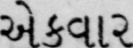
એકવાર
